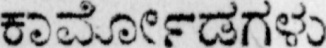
ಕಾರ್ಮೋಡಗಳು
